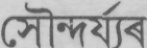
সৌন্দৰ্য্যৰ
